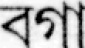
বগা
